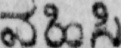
ವಹಿಸಿ
